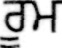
ਰੂਮ
